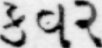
કવર
